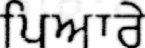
ਪਿਆਰੇ
